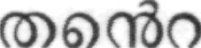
തന്റെ
